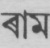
ৰাম
